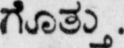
ಗೊತ್ತು.
